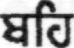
ਬਹਿ
